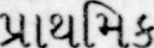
પ્રાથમિક
